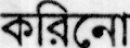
করিনো
